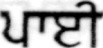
ਪਾਈ
